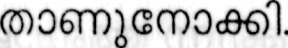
താണുനോക്കി.
